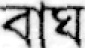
বাঘ
